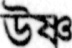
উষ্ণ
